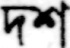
দশ
